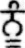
ਨੂੰ
